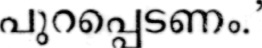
പുറപ്പെടണം.'
